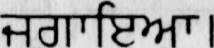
ਜਗਾਇਆ।
